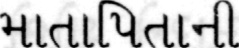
માતાપિતાની
